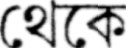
থেকে
